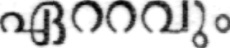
ഏററവും
